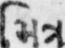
મિત્ર
